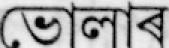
ভোলাৰ
